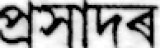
প্রসাদৰ
